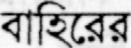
বাহিরের
